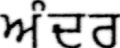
ਅੰਦਰ
